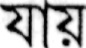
যায়
